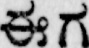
ಈಗ
